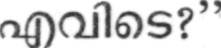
എവിടെ?"
